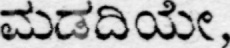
ಮಡದಿಯೇ,
